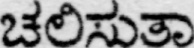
ಚಲಿಸುತಾ
